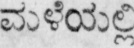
ಮಳೆಯಲ್ಲಿ
